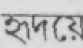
হৃদয়ে
